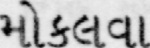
મોકલવા
